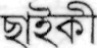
ছাইকী
